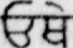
ਓਥੇ
